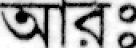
আরঃ
